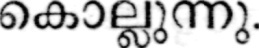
കൊല്ലുന്നു.
